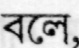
বলে,
